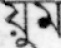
য়ুম
